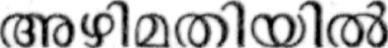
അഴിമതിയില്‍
